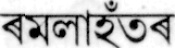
ৰমলাহঁতৰ
